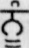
ਨੂੰ
